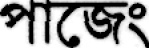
পাজেং
